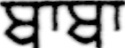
ਬਾਬਾ
